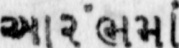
આરંભમાં
